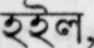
হইল,
